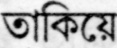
তাকিয়ে
